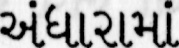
અંધારામાં
